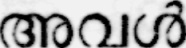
അവള്‍
